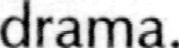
drama.
